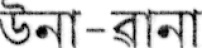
উনা-ৱানা
